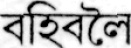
বহিবলৈ
